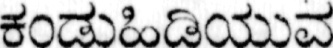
ಕಂಡುಹಿಡಿಯುವ
